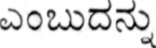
ಎಂಬುದನ್ನು
